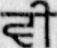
ਵੀ
